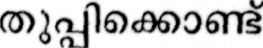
തുപ്പിക്കൊണ്ട്
